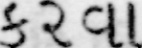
કરવા
